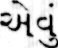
એવું
